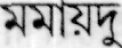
মমায়দু
